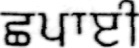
ਛਪਾਈ
